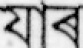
যাৰ
